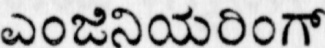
ಎಂಜಿನಿಯರಿಂಗ್
